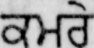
ਕਮਰੇ
